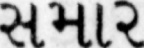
સમાર
